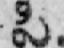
ಸಿ.
